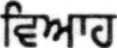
ਵਿਆਹ
